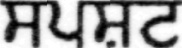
ਸਪਸ਼ਟ
